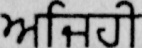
ਅਜਿਹੀ
